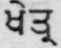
ਖੇਤ੍ਰ
